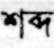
শব্দ
